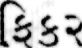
ફિકર
